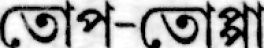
তোপ-তোপ্পা
